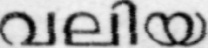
വലിയ
